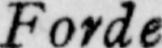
Forde
